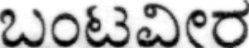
ಬಂಟವೀರ
